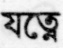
যত্নে
